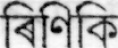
ৰিণিকি
